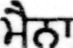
ਮੈਨਾ
